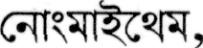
নোংমাইথেম
